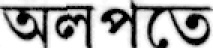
অলপতে
